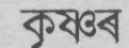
কৃষ্ণৰ
